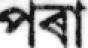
পৰা
